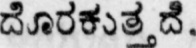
ದೊರಕುತ್ತದೆ.
